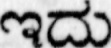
ಇದು
